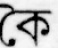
কৈ
